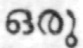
ഒരു
